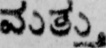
ಮತ್ತು
